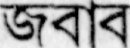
জবাব
